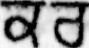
ਕਰ
